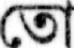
তো
